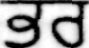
ਭਰ
